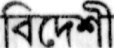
বিদেশী
